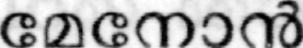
മേനോന്‍
